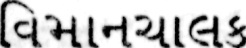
વિમાનચાલક
